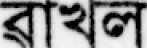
ৱাখল
